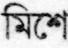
মিশে
